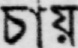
চায়
